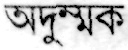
অদুম্মক
